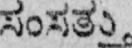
ಸಂಸತ್ತು
